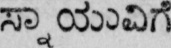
ಸ್ನಾಯುವಿಗೆ
